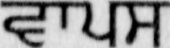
ਵਾਪਸ
